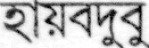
হায়বদুবু
